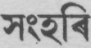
সংহৰি
